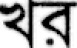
খর
